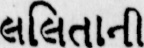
લલિતાની
